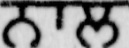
ਨਾਲ
